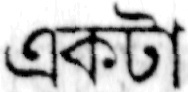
একটা
